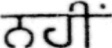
ਨਹੀਂ
